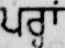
ਪਰ੍ਹਾਂ
